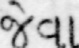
જેવા
